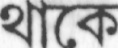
থাকে
